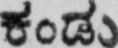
ಕಂಡು
